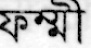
ফম্মী
